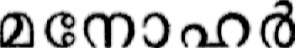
മനോഹര്‍
